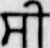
ਸੀ
